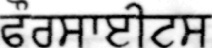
ਫੌਰਸਾਈਟਸ
